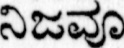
ನಿಜವೂ
